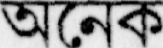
অনেক
